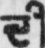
ਦੀ
